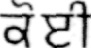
ਕੋਈ
